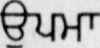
ਉਪਮਾ
